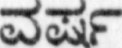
ವರ್ಷ
